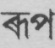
ৰূপ
